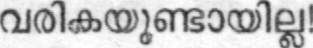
വരികയുണ്ടായില്ല!
